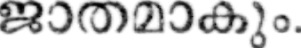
ജാതമാകും.
